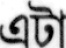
এটা
